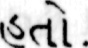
હતો.
